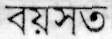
বয়সত
